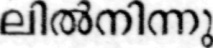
ലില്‍നിന്നു
